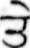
ਤੇ
